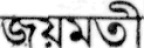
জয়মতী
